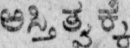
ಅಸ್ತಿತ್ವಕ್ಕೆ
